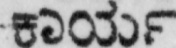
ಕಾರ್ಯ
